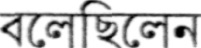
বলেছিলেন
